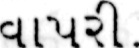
વાપરી.
